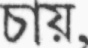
চায়,
